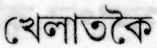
খেলাতকৈ
